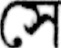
সে
